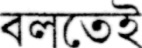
বলতেই
